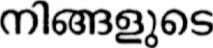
നിങ്ങളുടെ
